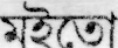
মইতো
